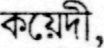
কয়েদী,
